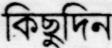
কিছুদিন
